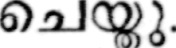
ചെയ്തു.
